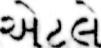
એટલે
